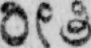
ರೀತಿ
